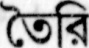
তৈরি
